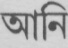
আনি
